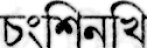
চংশিনখি
